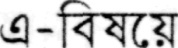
এ-বিষয়ে
